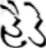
હૈડે
